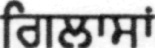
ਗਿਲਾਸਾਂ
